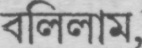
বলিলাম,
